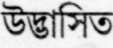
উদ্ভাসিত
